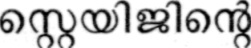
സ്റ്റെയിജിന്റെ
